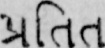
પ્રતિત
